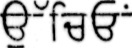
ਉੱਚਿਓਂ
